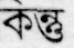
কিন্তু
